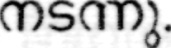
നടന്നു.
